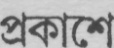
প্ৰকাশে
